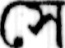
সে
